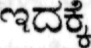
ಇದಕ್ಕೆ
